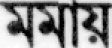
মমায়
